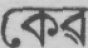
কেৱ
